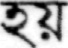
হয়
